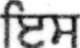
ਇਸ
